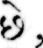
છે,
